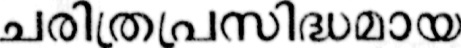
ചരിത്രപ്രസിദ്ധമായ
